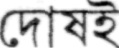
দোষই
